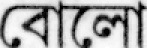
বোলো
